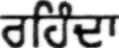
ਰਹਿੰਦਾ
